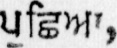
ਪੁਛਿਆ,
